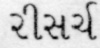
રીસર્ચ
